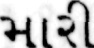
મારી
